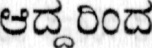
ಆದ್ದರಿಂದ
